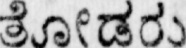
ತೋಡರು
